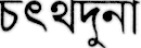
চৎথদুনা
